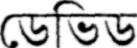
ডেভিড
